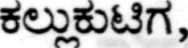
ಕಲ್ಲುಕುಟಿಗ,
